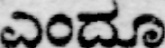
ಎಂದೂ
